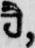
ਹੈ,
